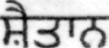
ਸ਼ੈਤਾਨ
